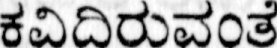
ಕವಿದಿರುವಂತೆ
